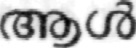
ആള്‍
